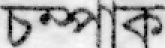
চম্পাক
